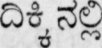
ದಿಕ್ಕಿನಲ್ಲಿ
